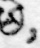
છે,
